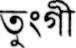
তুংগী
